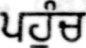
ਪਹੁੰਚ
